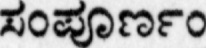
ಸಂಪೂರ್ಣಂ
